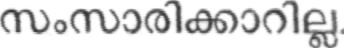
സംസാരിക്കാറില്ല.
